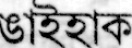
ঙাইহাক
